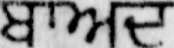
ਬਾਅਦ
